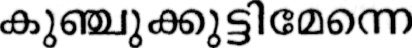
കുഞ്ചുക്കുട്ടിമേന്നെ
